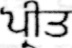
'ਪ੍ਰੀਤ
